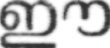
ഈ
